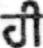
ਹੀ
